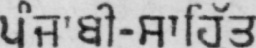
ਪੰਜਾਬੀ-ਸਾਹਿੱਤ
